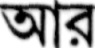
আর
